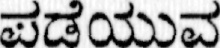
ಪಡೆಯುವ
